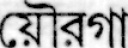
য়ৌরগা
